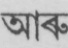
আৰু
